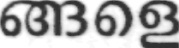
ങ്ങളെ
